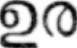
ഉര
